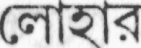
লোহার
